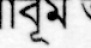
থাবূম
